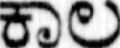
ಕಾಲ
